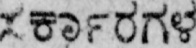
ಸರ್ಕಾರಗಳ
